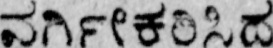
ವರ್ಗೀಕರಿಸಿದ
